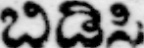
ಬಿಡಿಸಿ
